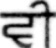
ਵੀ
